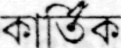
কার্তিক
